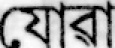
যোৱা
